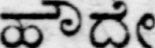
ಹೌದೇ
